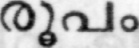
രൂപം
